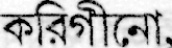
করিগীনো,
